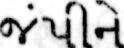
જંપીને
